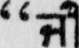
''ਜੀ
